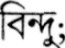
বিন্দু;
